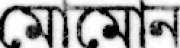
মোমোন
